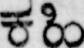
ಕಹಿ
